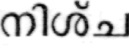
നിശ്ച
